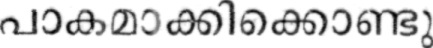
പാകമാക്കിക്കൊണ്ടു
